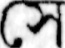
সে
